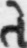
તે
